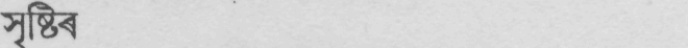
সৃষ্টিৰ
